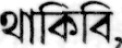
থাকিবি,
